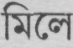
মিলে
